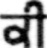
ਕੀ
